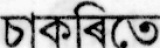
চাকৰিতে
